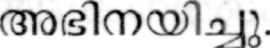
അഭിനയിച്ചു.
